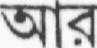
আর
